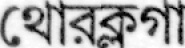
থোরক্লগা
